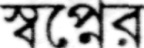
স্বপ্নের
